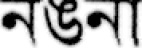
নঙনা
